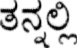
ತನ್ನಲ್ಲಿ
